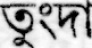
তুংদা
